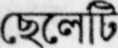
ছেলেটি
